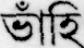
ভাঁহি
